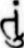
તું
